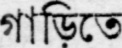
গাড়িতে
